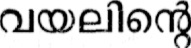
വയലിന്റെ
